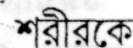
শরীরকে
